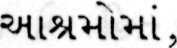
આશ્રમોમાં,
